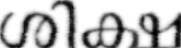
ശിക്ഷ
